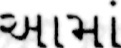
આમાં
